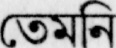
তেমনি
